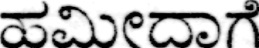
ಹಮೀದಾಗೆ
